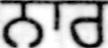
ਨਾਰ
